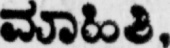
ಮಾಹಿತಿ,
